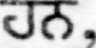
ਹਨ,
